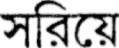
সরিয়ে
